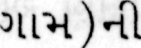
ગામ)ની
